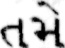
તમે
